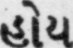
હોય
